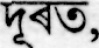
দূৰত,
